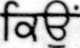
ਕਿਉਂ
